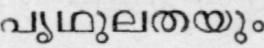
പൃഥുലതയും
